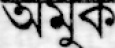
অমুক
